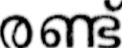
രണ്ട്
